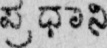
ಪ್ರಧಾನಿ
